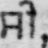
ਸੀ,
